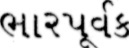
ભારપૂર્વક
